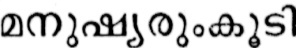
മനുഷ്യരുംകൂടി
